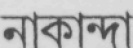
নাকান্দা
